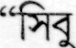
“সিবু
